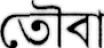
তৌবা
